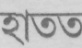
হাতত
